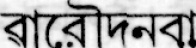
ৱারৌদনবা
